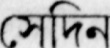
সেদিন
